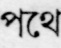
পথে
